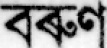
বৰুণ
